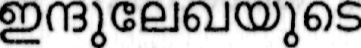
ഇന്ദുലേഖയുടെ
